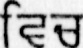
ਵਿਚ
